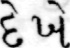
દેખે
